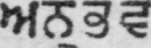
ਅਨੁਭਵ
